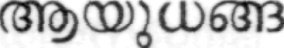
ആയുധങ്ങ
